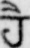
ਹੈ
